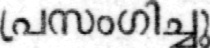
പ്രസംഗിച്ചു
